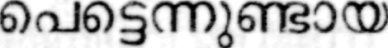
പെട്ടെന്നുണ്ടായ
